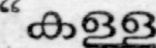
"കള്ള
